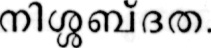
നിശ്ശബ്ദത.
